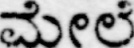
ಮೇಲೆ
